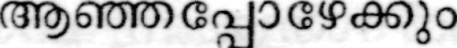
ആഞ്ഞപ്പോഴേക്കും
